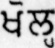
ਖੋਲ੍ਹ
